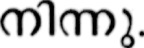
നിന്നു.
